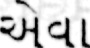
એવા
